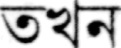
তখন
